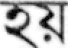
হয়
